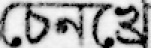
চেনখ্রে
